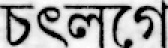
মখুৎনা
